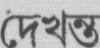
দেখন্ত
